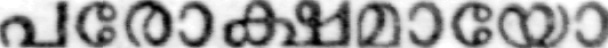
പരോക്ഷമായോ
